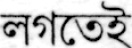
লগতেই
